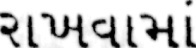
રાખવામાં
